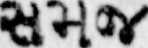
સમજ
